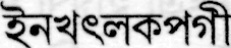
ইনখৎলকপগী
